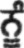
ਨੂੰ
